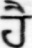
ਹੈ
